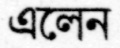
এলেন
